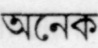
অনেক
